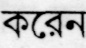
করেন
